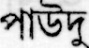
পাউদু
